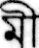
মী
